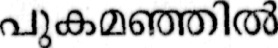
പുകമഞ്ഞില്‍
